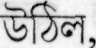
উঠিল,
